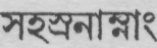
সহস্ৰনাম্নাং
